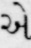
એ
